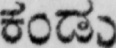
ಕಂಡು
